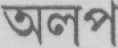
অলপ
